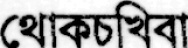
থোকচখিবা
